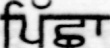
ਪਿੱਛਾ
